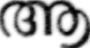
ആ
